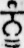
ਨੂੰ
